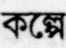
কল্পে
